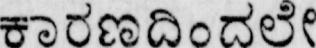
ಕಾರಣದಿಂದಲೇ
